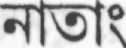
নাতাং
